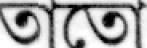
তাতো
